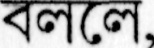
বললে,
